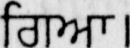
ਗਿਆ।
